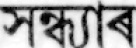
সন্ধ্যাৰ
